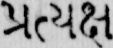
પ્રત્યક્ષ
